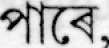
পাৰে,
